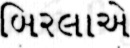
બિરલાએ
